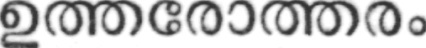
ഉത്തരോത്തരം
